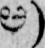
ಆ)
